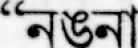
“নঙনা
